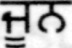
ਜੂਨ
